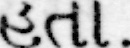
હતા.
